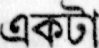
একটা
